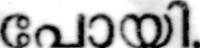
പോയി.
